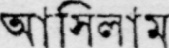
আসিলাম
